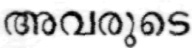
അവരുടെ
